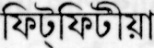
ফিট্‌ফিটীয়া
